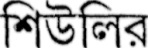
শিউলির
